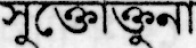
সুক্তোক্তুনা
